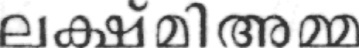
ലക്ഷ്മിഅമ്മ
